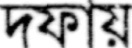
দফায়
